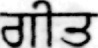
ਗੀਤ
